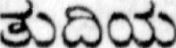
ತುದಿಯ
